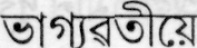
ভাগ্যৱতীয়ে
